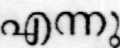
എന്നു
